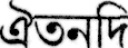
ঐতনদী
